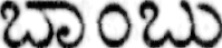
ಬಾಂಬು
